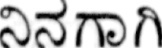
ನಿನಗಾಗಿ
